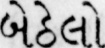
બેઠેલો
